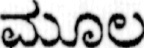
ಮೂಲ
